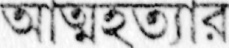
আত্মহত্যার
